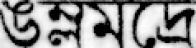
ঙম্লমদ্রে
